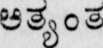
ಅತ್ಯಂತ
